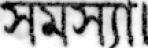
সমস্যা।
